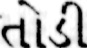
તોડી
